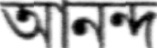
আনন্দ
